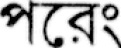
পরেং
